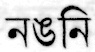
নঙনি
